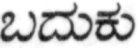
ಬದುಕು
